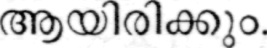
ആയിരിക്കും.
